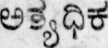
ಅತ್ಯಧಿಕ
